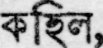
কহিল,
